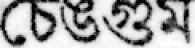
চেঙগুম
